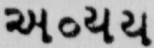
અવ્યય
